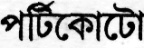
পৰ্টিকোটো
